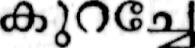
കുറച്ചേ
